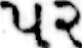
પર
